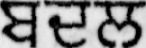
ਬਦਲ
